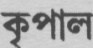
কৃপাল
